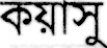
কয়াসু
